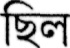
ছিল
